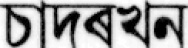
চাদৰখন
